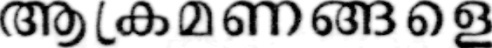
ആക്രമണങ്ങളെ
